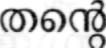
തന്റെ
